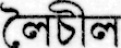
লৈচীল
